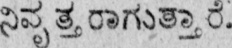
ನಿವೃತ್ತರಾಗುತ್ತಾರೆ.
